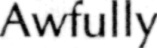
Awfully
